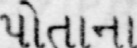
પોતાના
